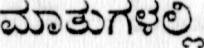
ಮಾತುಗಳಲ್ಲಿ
